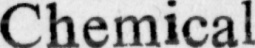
Chemical
